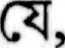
যে,
